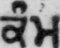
ਕੰਮ
